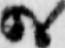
જ
